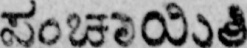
ಪಂಚಾಯಿತಿ
